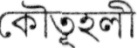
কৌতূহলী
